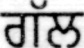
ਗੱਲ
